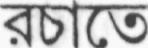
রচাতে
